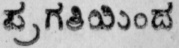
ಪ್ರಗತಿಯಿ೦ದ
